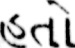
હતો
